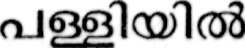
പള്ളിയില്‍
